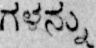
ಗಳನ್ನು
